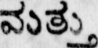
ಮತ್ತು
